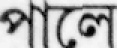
পালে
